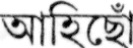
আহিছোঁ
